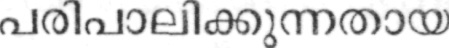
പരിപാലിക്കുന്നതായ
